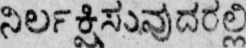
ನಿರ್ಲಕ್ಷಿಸುವುದರಲ್ಲಿ
